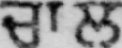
ਚਾਲ
